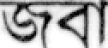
জবা
